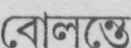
বোলন্তে
